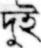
দুই
